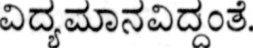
ವಿದ್ಯಮಾನವಿದ್ದಂತೆ.
